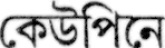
কেউপিনে
